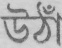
উঠাঁ
